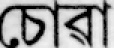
চোৱা
